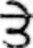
ਤੇ
